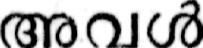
അവള്‍
